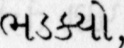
ભડક્યો,
